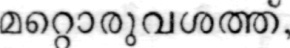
മറ്റൊരുവശത്ത്,
